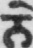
ਨੇ
